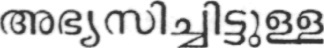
അഭ്യസിച്ചിട്ടുള്ള
